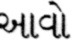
આવો
